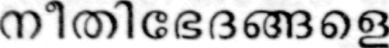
നീതിഭേദങ്ങളെ
